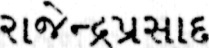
રાજેન્દ્રપ્રસાદ
